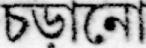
চড়ানো
